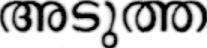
അടുത്ത
